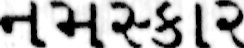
નમસ્કાર
